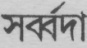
সৰ্ব্বদা
